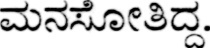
ಮನಸೋತಿದ್ದ.
